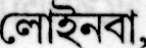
লোইনবা,
